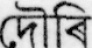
দৌৰি
